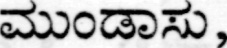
ಮುಂಡಾಸು,
